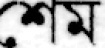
শেম
